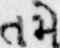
તમે
